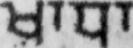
ਖਾਧਾ
